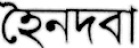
হৈনদবা
